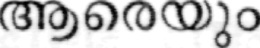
ആരെയും
